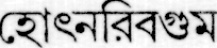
হোৎনরিবগুম
